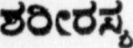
ಶರೀರಸ್ಯ
